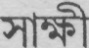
সাক্ষী
